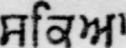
ਸਕਿਆ
